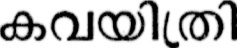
കവയിത്രി
